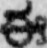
ಈ
